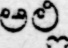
ಅಲ್ಲಿ
